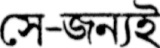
সে-জন্যই
